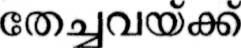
തേച്ചവയ്ക്ക്
